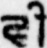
ਵੀ
